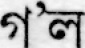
গ'ল
